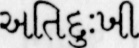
અતિદુઃખી
